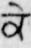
ਕੇ
